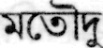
মতৌদু
